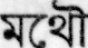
মথৌ
